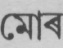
মোৰ
